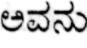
ಅವನು
